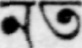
নত
